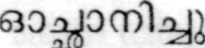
ഓച്ഛാനിച്ചു
